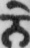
ਨੇ
